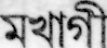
মখাগী
